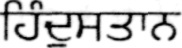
ਹਿੰਦੁਸਤਾਨ
